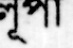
লুপা
